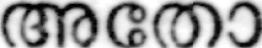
അതോ
